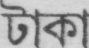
টাকা
